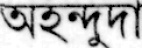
অহন্দুদা
